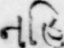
નહિ
